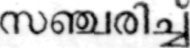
സഞ്ചരിച്ച്
